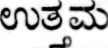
ಉತ್ತಮ
